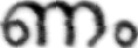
ണം
